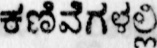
ಕಣಿವೆಗಳಲ್ಲಿ
